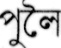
পুলৈ
